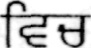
ਵਿਚ
